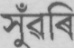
সুঁৱৰি
